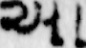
આ
